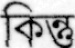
কিন্তু
